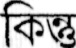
কিন্তু
